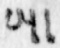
બા
